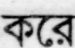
করে
